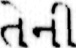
તેની
